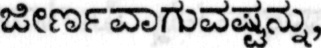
ಜೀರ್ಣವಾಗುವಷ್ಟನ್ನು,
